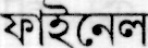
ফাইনেল
